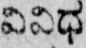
ವಿವಿಧ
